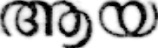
ആയ
